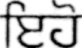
ਇਹੋ
